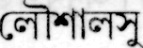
লৌশালসু
